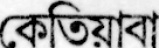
কেতিয়াবা
